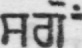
ਸਗੋਂ
